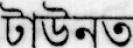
টাউনত
